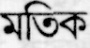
মতিক
